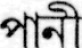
পানী
